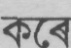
কৰে
